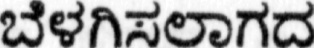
ಬೆಳಗಿಸಲಾಗದ
